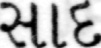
સાદ
